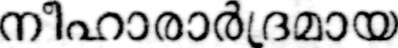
നീഹാരാര്‍ദ്രമായ
